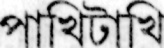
পাখিটাখি
